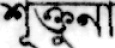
শূক্তুনা
